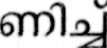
ണിച്ച്
